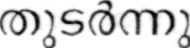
തുടര്‍ന്നു
